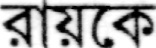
রায়কে
